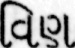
વિણ
